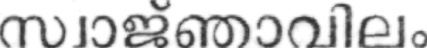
സ്വാജ്ഞാവിലം
